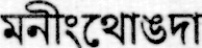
মনীংথোঙদা
